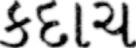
કદાચ
